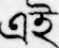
এই
